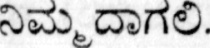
ನಿಮ್ಮದಾಗಲಿ.
